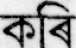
কৰি
